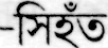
-সিহঁত
